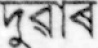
দুৱাৰ
